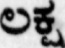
ಲಕ್ಷ
